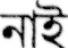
নাই
